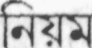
নিয়ম
